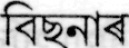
বিছনাৰ
